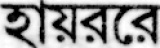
হায়ররে
